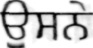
ਉਸਨੇ
